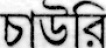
চাউরি
